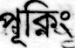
পূক্নিং
